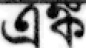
ত্রঙ্ক
